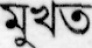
মুখত
